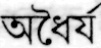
অধৈর্য
